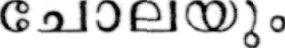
ചോലയും
